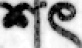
শৎ
